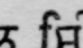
ਸਿ
